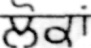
ਲੋਕਾਂ
